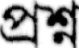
প্রশ্ন
